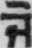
ਜੋ
